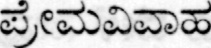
ಪ್ರೇಮವಿವಾಹ
